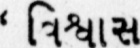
'વિશ્વાસ
